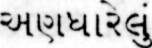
અણધારેલું
